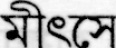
মীৎসে
